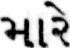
મારે
